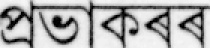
প্রভাকৰৰ
